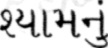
શ્યામનું
